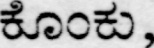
ಕೊಂಕು,
